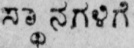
ಸ್ಥಾನಗಳಿಗೆ
